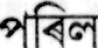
পৰিল
